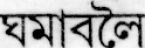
ঘমাবলৈ
